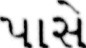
પાસે
